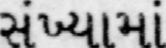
સંખ્યામાં
